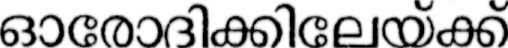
ഓരോദിക്കിലേയ്ക്ക്
